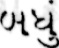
બધું
